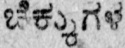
ಚೆಕ್ಕುಗಳ
